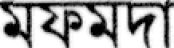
মফমদা
